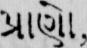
પ્રાણો,
